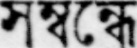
সম্বন্ধে
